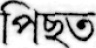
পিছত
